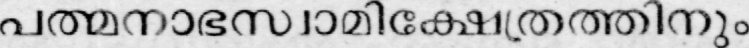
പത്മനാഭസ്വാമിക്ഷേത്രത്തിനും
